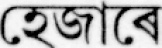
হেজাৰে
